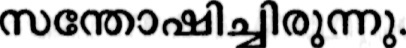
സന്തോഷിച്ചിരുന്നു.
